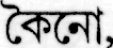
কৈনো,
